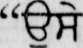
''ਉਸੇ
